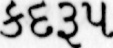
કદરૂપ
